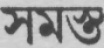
সমস্ত
